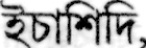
ইচাশিদি,
